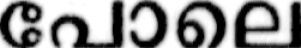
പോലെ
